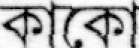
কাকো
